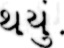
થયું.
